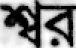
শ্বর
